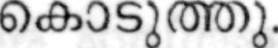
കൊടുത്തു.
